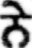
ਨੇ
